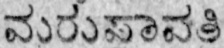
ಮರುಪಾವತಿ
